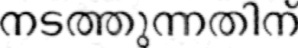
നടത്തുന്നതിന്
